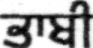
ਭਾਬੀ
